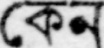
কেন
